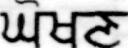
ਘੋਖਣ
